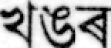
খঙৰ
